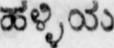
ಹಳ್ಳಿಯ
